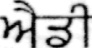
ਐਡੀ
